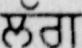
ਲੱਗ
